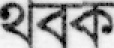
থবক
